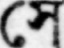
সে
